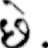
છે.
